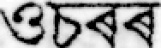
ওচৰৰ
